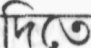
দিতে
